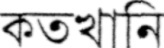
কতখানি
